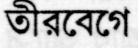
তীরবেগে
